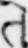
તે
